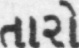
તારો
